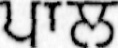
ਪਾਲ
